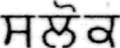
ਸਲੋਕ
